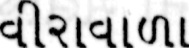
વીરાવાળા
